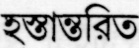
হস্তান্তরিত
